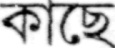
কাছে
